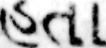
હતા
